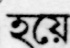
হয়ে
